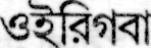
ওইরিগবা
